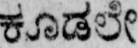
ಕೂಡಲೇ
